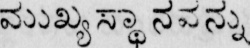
ಮುಖ್ಯಸ್ಥಾನವನ್ನು
